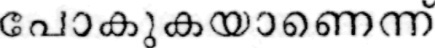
പോകുകയാണെന്ന്
